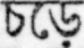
চড়ে
